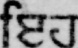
ਇਹ
